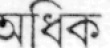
অধিক
